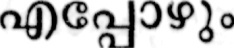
എപ്പോഴും
